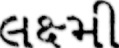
લક્ષ્મી
